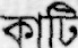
কাটি
